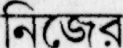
নিজের
